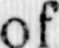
of
